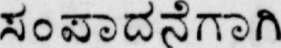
ಸಂಪಾದನೆಗಾಗಿ
